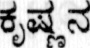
ಕೃಷ್ಣನ
